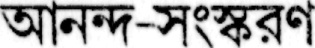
আনন্দ-সংস্করণ
